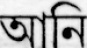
আনি
